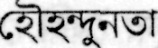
হৌহন্দুনতা
